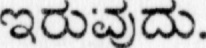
ಇರುವುದು.
